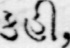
કહી,
